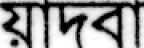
য়াদবা
